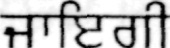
ਜਾਇਗੀ
